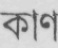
কাণ
